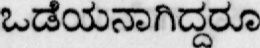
ಒಡೆಯನಾಗಿದ್ದರೂ
